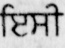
ਇਸੀ
